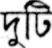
দুটি
